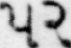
પર
